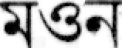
মওন
